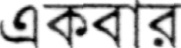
একবার
